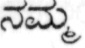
ನಮ್ಮ
